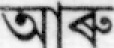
আৰু
